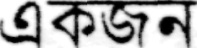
একজন
